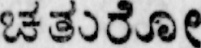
ಚತುರೋ
